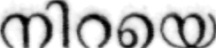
നിറയെ
